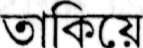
তাকিয়ে
